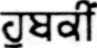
ਹੁਬਕੀਂ
